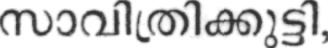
സാവിത്രിക്കുട്ടി,
